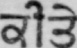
ਕੀਤੇ
